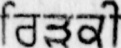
ਰਿੜਕੀ
